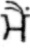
ਮੈਂ
